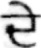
ਦੇ
